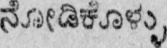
ನೋಡಿಕೊಳ್ಳು
